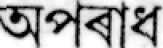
অপৰাধ
